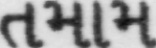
તમામ
